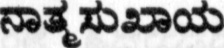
ನಾತ್ಮಸುಖಾಯ
